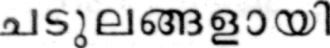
ചടുലങ്ങളായി
